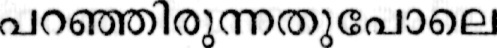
പറഞ്ഞിരുന്നതുപോലെ
